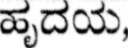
ಹೃದಯ,
